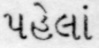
પહેલાં
